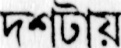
দশটায়
